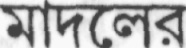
মাদলের
